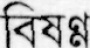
বিষণ্ণ
